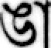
ঙা
